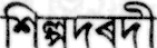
শিল্পদৰদী
